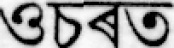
ওচৰত
